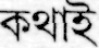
কথাই
